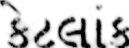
કેટલાંક
